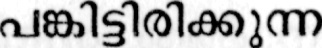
പങ്കിട്ടിരിക്കുന്ന
